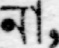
না,
